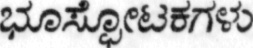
ಭೂಸ್ಫೋಟಕಗಳು
